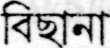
বিছানা
